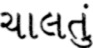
ચાલતું
